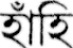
হাঁহি
